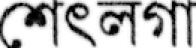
শেৎলগা
